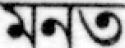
মনত
